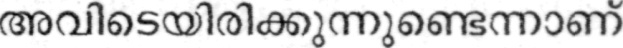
അവിടെയിരിക്കുന്നുണ്ടെന്നാണ്
